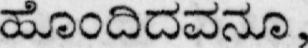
ಹೊಂದಿದವನೂ,
